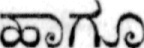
ಹಾಗೂ
